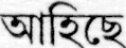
আহিছে
